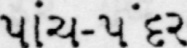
પાંચ-પંદર
